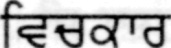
ਵਿਚਕਾਰ
